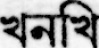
খনখি
